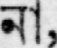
না,
